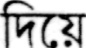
দিয়ে
